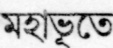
মহাভূতে
